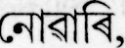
নোৱাৰি,
